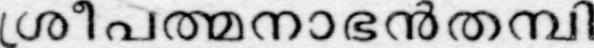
ശ്രീപത്മനാഭന്‍തമ്പി
